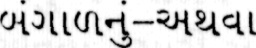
બંગાળનું-અથવા
